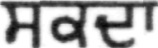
ਸਕਦਾ
